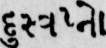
દુસ્વપ્નો
